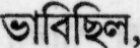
ভাবিছিল,
